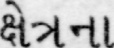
ક્ષેત્રના
